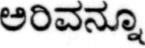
ಅರಿವನ್ನೂ
